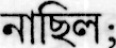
নাছিল;
